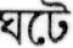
ঘটে
